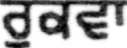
ਰੁਕਵਾ
